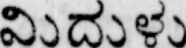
ಮಿದುಳು
